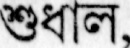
শুধাল,
